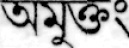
অমুক্তং
